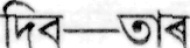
দিব-তাৰ
